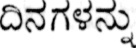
ದಿನಗಳನ್ನು
